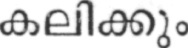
കലിക്കും
